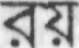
রয়
